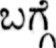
ಬಗ್ಗೆ
